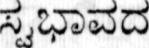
ಸ್ವಭಾವದ
